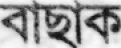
বাছাক
